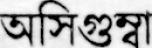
অসিগুম্বা
